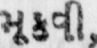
મૂકવી,
